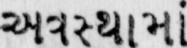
અવસ્થામાં
